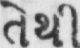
તેથી
